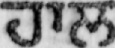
ਹਾਲ
